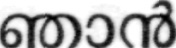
ഞാന്‍
